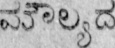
ಮೌಲ್ಯದ
